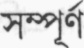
সম্পূর্ণ
